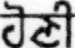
ਹੋਣੀ
